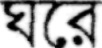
ঘরে
